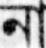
না
